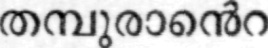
തമ്പുരാന്റെ
